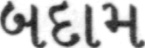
બદામ
